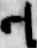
ન
